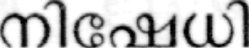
നിഷേധി
